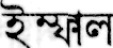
ইম্ফাল
